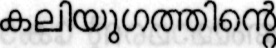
കലിയുഗത്തിന്റെ
